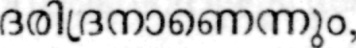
ദരിദ്രനാണെന്നും,
